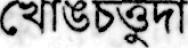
খোঙচত্তুদা
